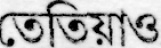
তেতিয়াও
